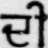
ਦੀ
